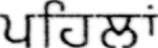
ਪਹਿਲਾਂ
